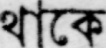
থাকে
